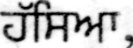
ਹੱਸਿਆ,
